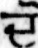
ਦੋ
